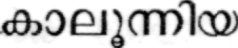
കാലൂന്നിയ
